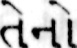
તેનો
